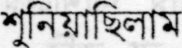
শুনিয়াছিলাম
